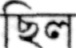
ছিল
